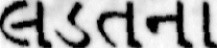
લડતના
